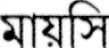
মায়সি
